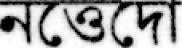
নত্তেদো
